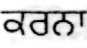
ਕਰਨਾ
